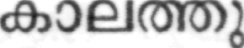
കാലത്തു
